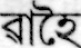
ৱাহৈ
